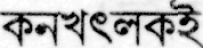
কনখৎলকই
